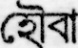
হৌবা
